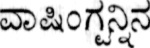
ವಾಷಿಂಗ್ಟನ್ನಿನ
